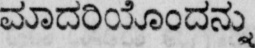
ಮಾದರಿಯೊಂದನ್ನು
